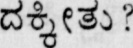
ದಕ್ಕೀತು?
